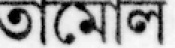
তামোল
